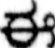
ಈ
